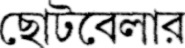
ছোটবেলার
